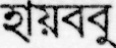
হায়ববু
